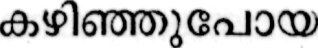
കഴിഞ്ഞുപോയ
